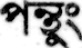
পন্থুং
